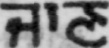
ਜਾਣ
